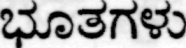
ಭೂತಗಳು
